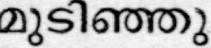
മുടിഞ്ഞു
